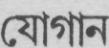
যোগান
